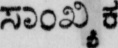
ಸಾಂಖ್ಯಿಕ
